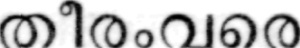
തീരംവരെ
